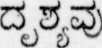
ದೃಶ್ಯವು
